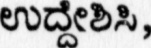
ಉದ್ದೇಶಿಸಿ,
